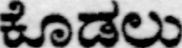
ಕೊಡಲು
